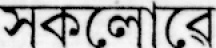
সকলোৱে
